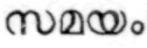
സമയം
